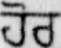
ਹੋਰ
